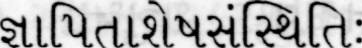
જ્ઞાપિતાશેષસંસ્થિતિઃ
